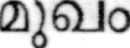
മുഖം
